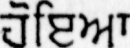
ਹੋਇਆ
